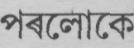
পৰলোকে
